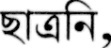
ছাত্রনি,
